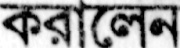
করালেন
